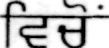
ਵਿਚੋਂ
